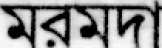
মরমদা
